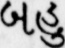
બહુ
